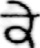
ਕੇ
